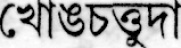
খোঙচত্তুদা
